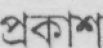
প্রকাশ
